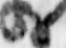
જ
